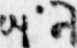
બંને
